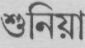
শুনিয়া
